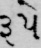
રૂપે
